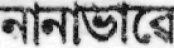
নানাভাৱে
